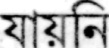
যায়নি
